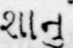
શાનું
